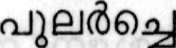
പുലര്‍ച്ചെ
